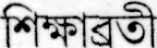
শিক্ষাব্রতী
